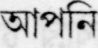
আপনি
